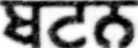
ਬਟਨ
